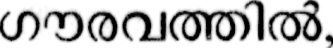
ഗൌരവത്തില്‍,
